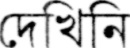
দেখিনি
